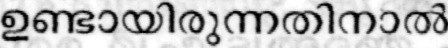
ഉണ്ടായിരുന്നതിനാല്‍
